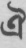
ঐ
